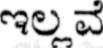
ಇಲ್ಲವೆ
